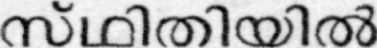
സ്ഥിതിയില്‍
